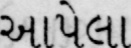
આપેલા
